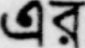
এর
